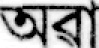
অৱা
